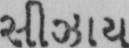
સીઝાય
